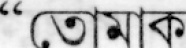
"তোমাক
